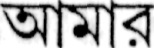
আমার
